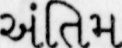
અંતિમ
